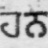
ਹਨ
